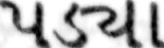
પડ્યા
